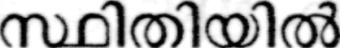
സ്ഥിതിയില്‍
